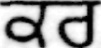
ਕਰ
